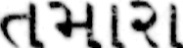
તમારા
